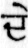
ਦੇ
